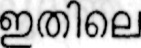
ഇതിലെ
